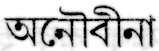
অনৌবীনা
